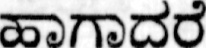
ಹಾಗಾದರೆ
